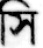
সি
